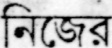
নিজের
